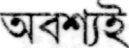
অবশ্যই
